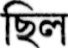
ছিল
